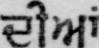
ਦੀਆਂ
